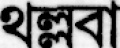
থল্লবা
